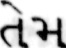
તેમ
